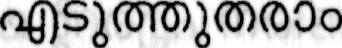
എടുത്തുതരാം
